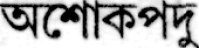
অশোকপদু
